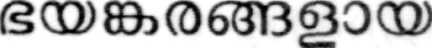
ഭയങ്കരങ്ങളായ
